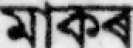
মাকৰ
